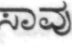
ಸಾವು
